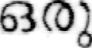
ഒരു
